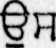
ਉਸ
